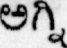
ಅಗ್ನಿ
